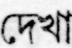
দেখা
